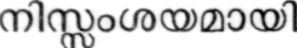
നിസ്സംശയമായി
